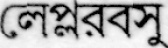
লেপ্লরবসু
